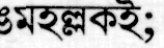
ঙমহল্লকই;
